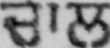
ਚਾਲ
